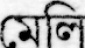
মেলি
